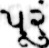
પૂરું
